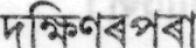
দক্ষিণৰপৰা
